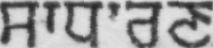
ਸਾਧਾਰਣ
